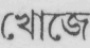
খোজে
